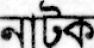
নাটক
